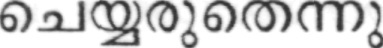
ചെയ്യരുതെന്നു
